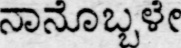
ನಾನೊಬ್ಬಳೇ
